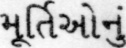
મૂર્તિઓનું
